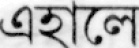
এহালে
